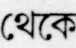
থেকে
